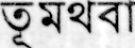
তূমথবা
